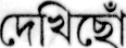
দেখিছোঁ
